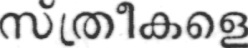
സ്ത്രീകളെ
